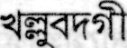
খল্লুবদগী
